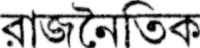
রাজনৈতিক
